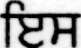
ਇਸ
